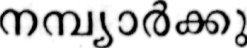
നമ്പ്യാര്‍ക്കു
